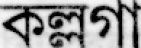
কল্লগা
